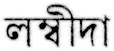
লম্বীদা
